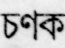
চণক
